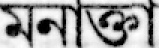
মনাক্তা
